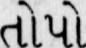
તોપો
